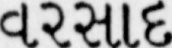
વરસાદ
